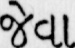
જેવા
